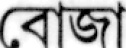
বোজা
